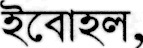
ইবোহল,
